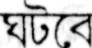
ঘটবে
